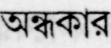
অন্ধকার
